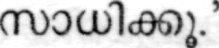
സാധിക്കൂ.’
